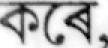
কৰে,
